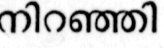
നിറഞ്ഞി
